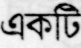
একটি
